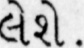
લેશે.
